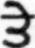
ਤੇ
